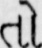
તો
